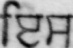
ਇਸ
